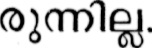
രുന്നില്ല.
